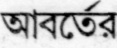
আবর্তের
